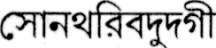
সোনথরিবদুদগী
